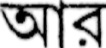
আর
